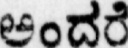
ಅಂದರೆ
